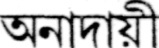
অনাদায়ী
